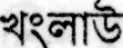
খংলাই
